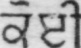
ਕੋਈ
